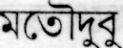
মতৌদুবু
